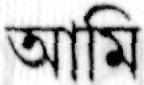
আমি
